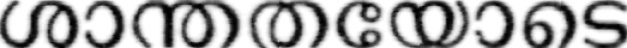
ശാന്തതയോടെ
